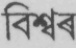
বিশ্বৰ
